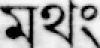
মথং
